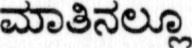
ಮಾತಿನಲ್ಲೂ
